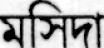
মসিদা
